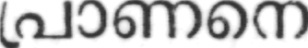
പ്രാണനെ
